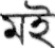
মই
